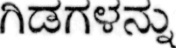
ಗಿಡಗಳನ್ನು
